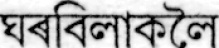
ঘৰবিলাকলৈ
